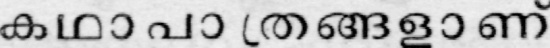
കഥാപാത്രങ്ങളാണ്
